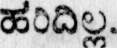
ಹರಿದಿಲ್ಲ.
